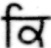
ਕਿ
